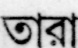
তারা
